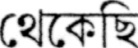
থেকেছি
